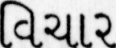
વિચાર
